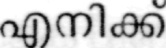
എനിക്ക്
